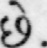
છે.
